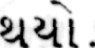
થયો.
